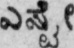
ಎಷ್ಟೇ
